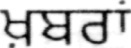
ਖ਼ਬਰਾਂ
